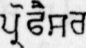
ਪ੍ਰੋਫੈਸਰ
